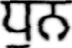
ਧੁਨ
